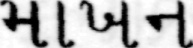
માખન
